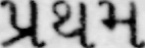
પ્રથમ
